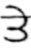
ਤੇ
